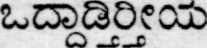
ಒದ್ದಾಡ್ತಿರ್‍ತೀಯ
